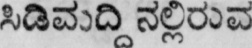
ಸಿಡಿಮದ್ದಿನಲ್ಲಿರುವ
